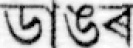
ডাঙৰ
